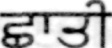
ਛਾਤੀ
